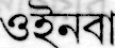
ওইনবা
